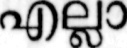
എല്ലാ
